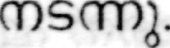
നടന്നു.
